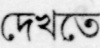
দেখতে
